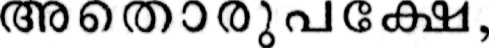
അതൊരുപക്ഷേ,
